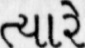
ત્યારે
